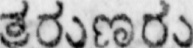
ತರುಣರು
